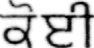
ਕੋਈ
